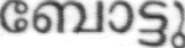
ബോട്ടു
